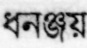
ধনঞ্জয়
